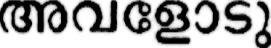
അവളോടു
